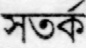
সতর্ক
